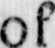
of
